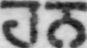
ਹਨ
